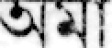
অমা
